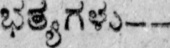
ಭತ್ಯಗಳು--
